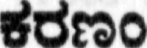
ಕರಣಂ
